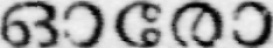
ഓരോ
